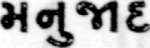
મનુજાદ
